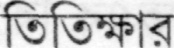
তিতিক্ষার
